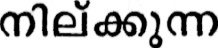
നില്ക്കുന്ന
